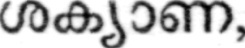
ശക്യാണ,
